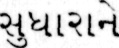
સુધારાને
